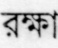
রক্ষা
